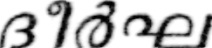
ദീര്‍ഘ
